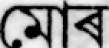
মোৰ
